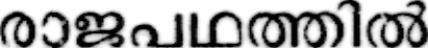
രാജപഥത്തില്‍
